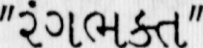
"રંગભક્ત"
